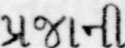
પ્રજાની
